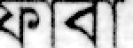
ফাবা
